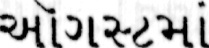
ઑગસ્ટમાં
